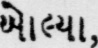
બોલ્યા,
